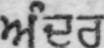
ਅੰਦਰ
